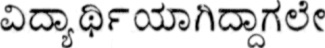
ವಿದ್ಯಾರ್ಥಿಯಾಗಿದ್ದಾಗಲೇ
